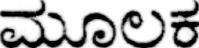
ಮೂಲಕ
